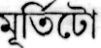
মূর্তিটো
